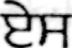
ਏਸ
